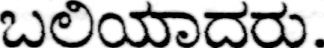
ಬಲಿಯಾದರು.
